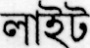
লাইট
